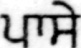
ਪਾਸੇ
